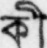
কী
